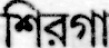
শিরগা
